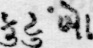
બીજું
